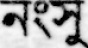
নংসু
